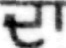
ਦਾ
